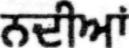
ਨਦੀਆਂ
